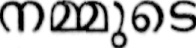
നമ്മുടെ
